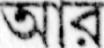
আর
